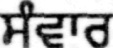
ਸੰਵਾਰ
